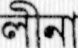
লীনা
